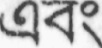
এবং
